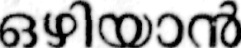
ഒഴിയാന്‍
